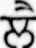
ਲੈ
